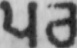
ਪਰ
